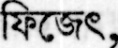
ফিজেৎ,
